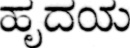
ಹೃದಯ
